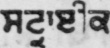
ਸਟ੍ਰਾਈਕ
